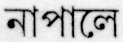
নাপালে
